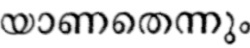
യാണതെന്നും
